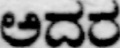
ಅದರ
